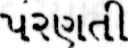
પરણતી
